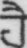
ਹੈ
